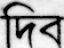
দিব
